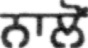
ਨਾਲੋਂ
